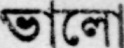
ভালো
